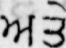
ਅਤੇ
